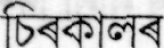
চিৰকালৰ
